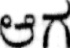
ಆಗ
